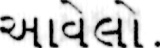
આવેલો.
